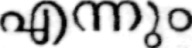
എന്നും
